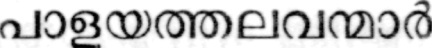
പാളയത്തലവന്മാര്‍
